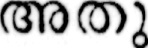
അതു
